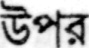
উপর
